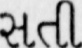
સતી
